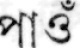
পাওঁ
